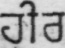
ਹੀਰ
